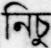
নিচু
